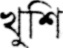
খুশি
